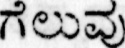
ಗೆಲುವು
